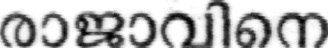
രാജാവിനെ
